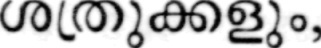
ശത്രുക്കളും,
